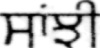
ਸਾਂਝੀ
